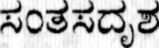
ಸಂತಸದೃಶ
